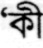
‘কী
